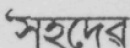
'সহদেৱ
